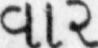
વાર
